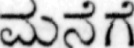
ಮನೆಗೆ
